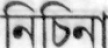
নিচিনা
